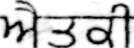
ਐਤਕੀ
